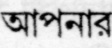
আপনার
